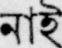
নাই
